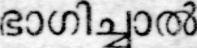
ഭാഗിച്ചാല്‍
